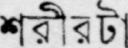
শরীরটা
